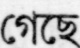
গেছে
